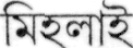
মিহলাই
